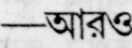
–আরও
